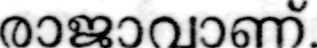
രാജാവാണ്.
